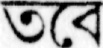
তবে
